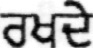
ਰਖਦੇ
